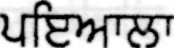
ਪਇਆਲਾ
